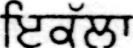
ਇਕੱਲਾ
